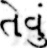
તેવું
